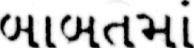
બાબતમાં
